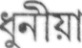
ধুনীয়া
